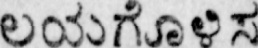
ಲಯಗೊಳಿಸ
